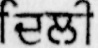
ਦਿਲੀ
